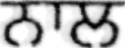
ਨਾਲ
